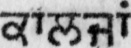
ਕਾਲਜਾਂ
